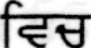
ਵਿਚ
